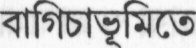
বাগিচাভূমিতে
